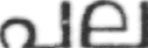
പല
